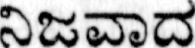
ನಿಜವಾದ
